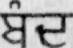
ਬੰਦ
